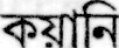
কয়ানি
